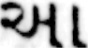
આ
